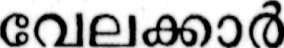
വേലക്കാര്‍
